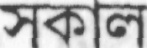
সকাল
